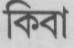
কিবা
